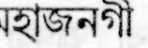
মহাজনগী
